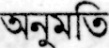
অনুমতি
